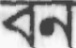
বন
